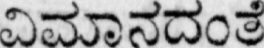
ವಿಮಾನದಂತೆ
